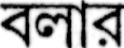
বলার
